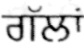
ਗੱਲਾਂ
